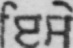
ਇਸੇ
